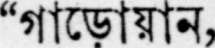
‘‘গাড়োয়ান,
